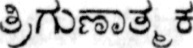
ತ್ರಿಗುಣಾತ್ಮಕ
